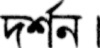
দর্শন।
